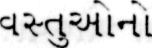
વસ્તુઓનો
